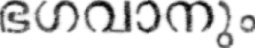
ഭഗവാനും
